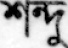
শন্দু
